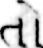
તો
